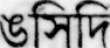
ঙসিদি
